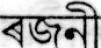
ৰজনী
